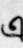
এ
